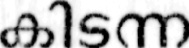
കിടന്ന
